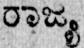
ರಾಜ್ಯ
